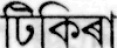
টিকিৰা
